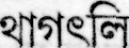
থাগৎলি
